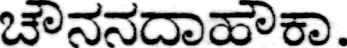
ಚೌನನದಾಹೌಕಾ.
